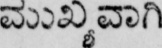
ಮುಖ್ಯವಾಗಿ
